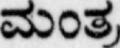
ಮಂತ್ರ
